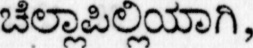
ಚೆಲ್ಲಾಪಿಲ್ಲಿಯಾಗಿ,
